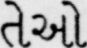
તેઓ
